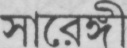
সারেঙ্গী
